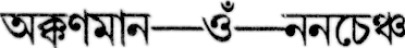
অক্কণমান-ওঁ-ননচেঞ্চ
